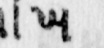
આંખ
